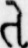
તે
